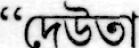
"দেউতা
